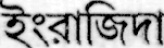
ইংরাজিদা
